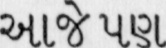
આજેપણ
